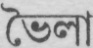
ভৈলা
